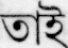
তাই
